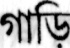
গাড়ি
